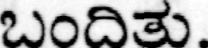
ಬಂದಿತು.
